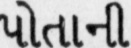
પોતાની
